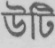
উটি
